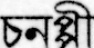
চনপ্পী
